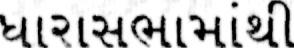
ધારાસભામાંથી
